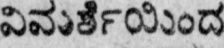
ವಿಮರ್ಶೆಯಿಂದ
